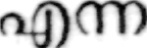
എന്ന
